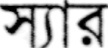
স্যার
